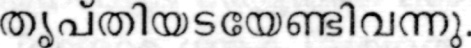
തൃപ്തിയടയേണ്ടിവന്നു.
